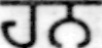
ਹਨ
